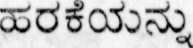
ಹರಕೆಯನ್ನು
